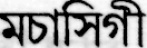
মচাসিগী
